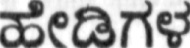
ಹೇಡಿಗಳ
